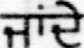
ਜਾਂਦੇ
